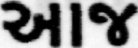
આજ
